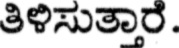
ತಿಳಿಸುತ್ತಾರೆ.
